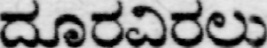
ದೂರವಿರಲು
